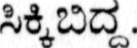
ಸಿಕ್ಕಿಬಿದ್ದ.
